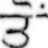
ਤੋਂ
